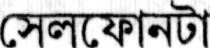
সেলফোনটা
